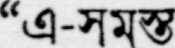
‘‘এ-সমস্ত
